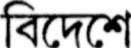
বিদেশে
